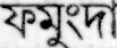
ফমুংদা
